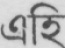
এহি
